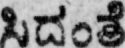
ಸಿದಂತೆ
